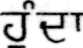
ਹੁੰਦਾ
